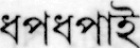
ধপধপাই
